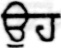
ਉਹ
